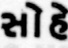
સોહે
